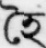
হৈ
